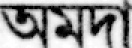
অমদা
